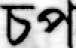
চপ
